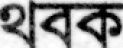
থবক
